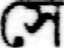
সে
